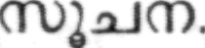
സൂചന.
